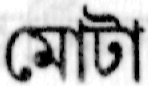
মোটা
